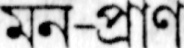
মন-প্রাণ
